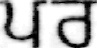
ਪਰ
